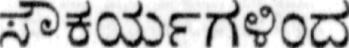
ಸೌಕರ್ಯಗಳಿಂದ
